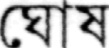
ঘোষ
